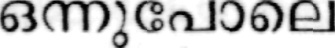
ഒന്നുപോലെ
